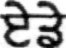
ਏਡੇ
